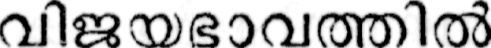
വിജയഭാവത്തില്‍
